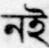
নই
